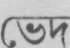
ভেদ
